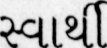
સ્વાર્થી
